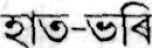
হাত-ভৰি
